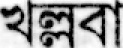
খল্লবা
